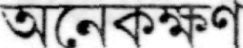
অনেকক্ষণ
